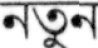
নতুন
